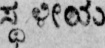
ಸ್ಥಳೀಯ
